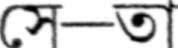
সে–তা
